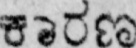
ಕಾರಣ
